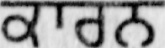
ਕਾਰਨ
